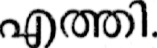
എത്തി.
